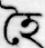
হৈ
